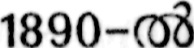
1890-ല്‍
